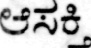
ಆಸಕ್ತಿ
